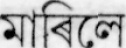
মাৰিলে
